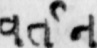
વર્તન
